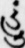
હું
